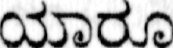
ಯಾರೂ
